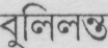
বুলিলন্ত
